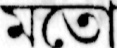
মতো
